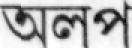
অলপ
